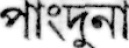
পাংদুনা
